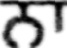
ਨਾ
